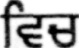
ਵਿਚ
